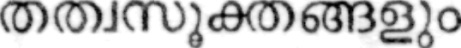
തത്വസൂക്തങ്ങളും
